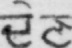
ਦੇਣ
